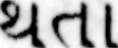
થતા
